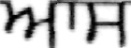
ਆਸ
